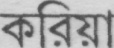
করিয়া
